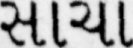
સાચા
